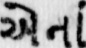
એના
